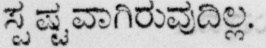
ಸ್ಪಷ್ಟವಾಗಿರುವುದಿಲ್ಲ.
